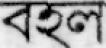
বহল
